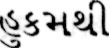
હુકમથી
